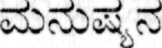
ಮನುಷ್ಯನ
